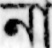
না
